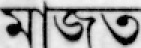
মাজত
